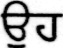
ਉਹ
